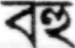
বহু
